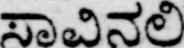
ಸಾವಿನಲಿ
